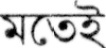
মতেই
